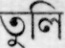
তুলি
